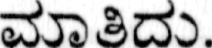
ಮಾತಿದು.
